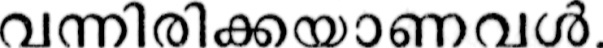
വന്നിരിക്കയാണവള്‍.
